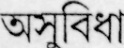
অসুবিধা
